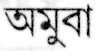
অমুবা
